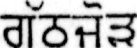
ਗੱਠਜੋੜ
